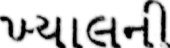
ખ્યાલની
